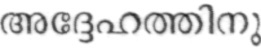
അദ്ദേഹത്തിനു
